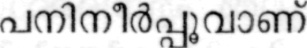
പനിനീര്‍പ്പൂവാണ്
